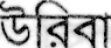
উরিবা
